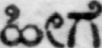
ಹೀಗೆ
